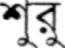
শুরু
